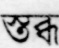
স্তব্ধ
